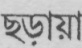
ছড়ায়া
